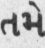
તમે
